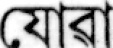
যোৱা
